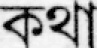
কথা
